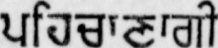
ਪਹਿਚਾਣਾਗੀ
